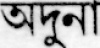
অদুনা
